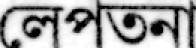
লেপতনা
